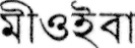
মীওইবা
